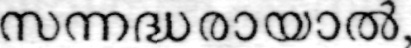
സന്നദ്ധരായാല്‍,
